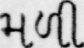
મળી
